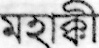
মহাক্কী
